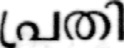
പ്രതി
